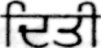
ਦਿਤੀ
